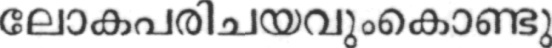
ലോകപരിചയവുംകൊണ്ടു
